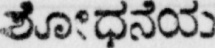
ಶೋಧನೆಯ
